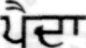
ਪੈਦਾ
